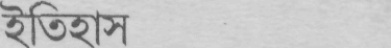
ইতিহাস
